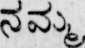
ನಮ್ಮ
